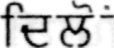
ਦਿਲੋਂ
